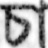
চা
